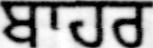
ਬਾਹਰ
